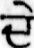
ਦੇ
